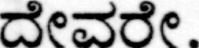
ದೇವರೇ.
